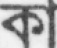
কা
